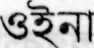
ওইনা
